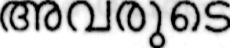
അവരുടെ
